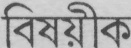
বিষয়ীক
